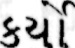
કર્યો
